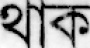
থাক
